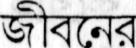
জীবনের
